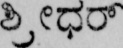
ಶ್ರೀಧರ್
